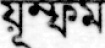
য়ুম্ফম
